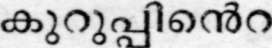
കുറുപ്പിന്റെ
